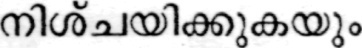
നിശ്ചയിക്കുകയും
